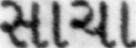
સાચા
